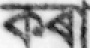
কৰা
